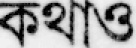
কথাও
